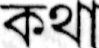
কথা
